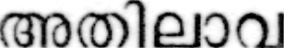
അതിലാവ
